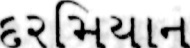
દરમિયાન
